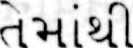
તેમાંથી
